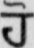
ਹੋ
